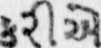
કરીએ
